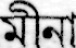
মীনা
